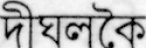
দীঘলকৈ
